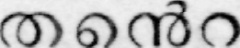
തന്റെ
